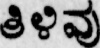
ತಿಳಿವು
